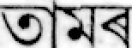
তামৰ
